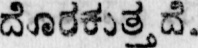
ದೊರಕುತ್ತದೆ.
